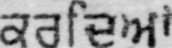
ਕਰਦਿਆਂ
